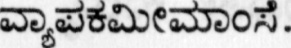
ವ್ಯಾಪಕಮೀಮಾಂಸೆ.
